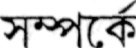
সম্পর্কে
